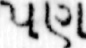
પણ
